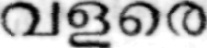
വളരെ
